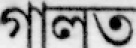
গালত
